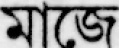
মাজে
